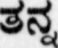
ತನ್ನ
